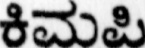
ಕಿಮಪಿ
